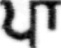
ਪਾ
